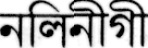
নলিনীগী
